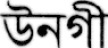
উনগী
